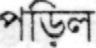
পড়িল
